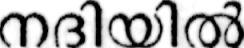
നദിയില്‍
